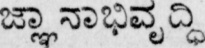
ಜ್ಞಾನಾಭಿವೃದ್ಧಿ
